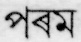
পৰম
